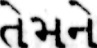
તેમને
